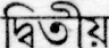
দ্বিতীয়
